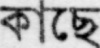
কাছে
